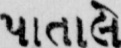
પાતાલે
